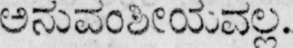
ಅನುವಂಶೀಯವಲ್ಲ.
